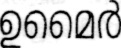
ഉമൈര്‍
